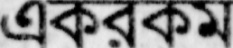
একরকম
